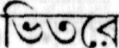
ভিতরে
